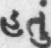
હતું
